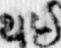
થઈ
